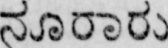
ನೂರಾರು
